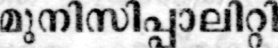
മുനിസിപ്പാലിറ്റി
